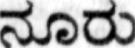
ನೂರು
